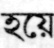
হয়ে
